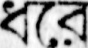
ধরে
